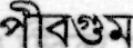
পীবগুম
